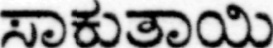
ಸಾಕುತಾಯಿ
